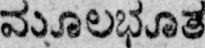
ಮೂಲಭೂತ
